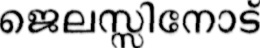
ജെലസ്സിനോട്
